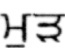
ਮੁੜ
